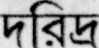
দরিদ্র
